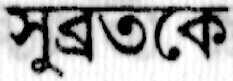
সুব্রতকে
